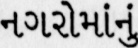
નગરોમાંનું
